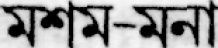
মশম-মনা
